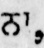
ਨਾ,
